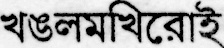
খঙলমখিরোই
